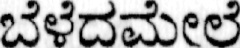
ಬೆಳೆದಮೇಲೆ
